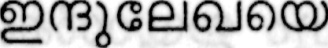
ഇന്ദുലേഖയെ
